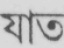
যাত
